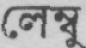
লেম্বু
